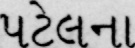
પટેલના
